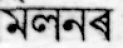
মিলনৰ
